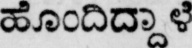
ಹೊಂದಿದ್ದಾಳೆ
